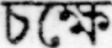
চক্ষে
